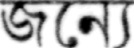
জন্যে
